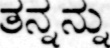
ತನ್ನನ್ನು
